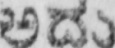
ಅದು
